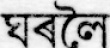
ঘৰলৈ
